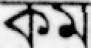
কম
